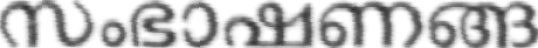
സംഭാഷണങ്ങ
